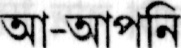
আ-আপনি
